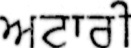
ਅਟਾਰੀ
